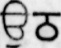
ਉਠ
